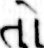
તો
